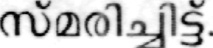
സ്മരിച്ചിട്ട്.
